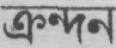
ক্ৰন্দন
